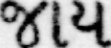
જાય
